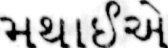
મથાઈએ
